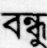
বন্ধু
